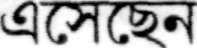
এসেছেন
